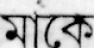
মাকে
